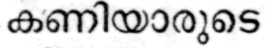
കണിയാരുടെ
